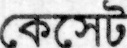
কেসেট
